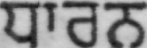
ਧਾਰਨ
